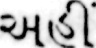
અહીં
